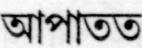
আপাতত
